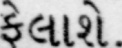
ફેલાશે.
